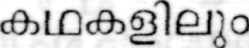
കഥകളിലും
